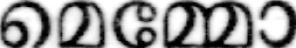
മെമ്മോ
